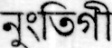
নুংতিগী
